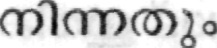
നിന്നതും
